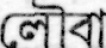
লৌবা
